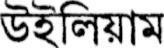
উইলিয়াম
